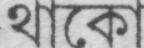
থাকো
